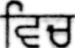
ਵਿਚ
